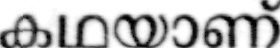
കഥയാണ്
